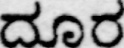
ದೂರ
